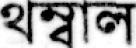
থম্বাল
